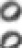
ঃ
